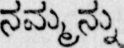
ನಮ್ಮನ್ನು
